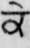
ਕੇ
